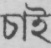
চাই
